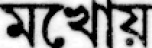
মখোয়
